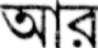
আর
